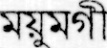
ময়ুমগী
